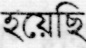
হয়েছি
